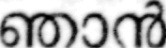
ഞാന്‍
